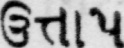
ઉત્તાપ
